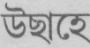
উছাহে
